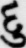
દુ
